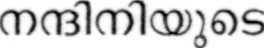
നന്ദിനിയുടെ
